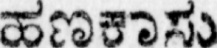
ಹಣಕಾಸು
